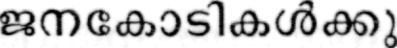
ജനകോടികള്‍ക്കു
